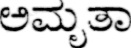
ಅಮೃತಾ
